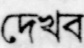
দেখব
